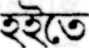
হইতে
